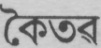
কৈতৱ
